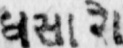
ધસારો
